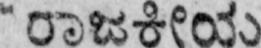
ರಾಜಕೀಯ
